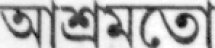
আশ্রমতো
